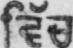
ਵਿੱਚ
